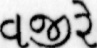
વજીરે
